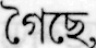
গৈছে,
